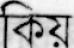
কিয়
